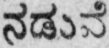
ನಡುವೆ
